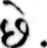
છે.
